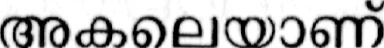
അകലെയാണ്
